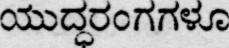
ಯುದ್ಧರಂಗಗಳೂ
